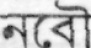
নবৌ
